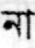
না
